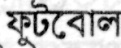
ফুটবোল
